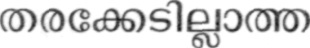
തരക്കേടില്ലാത്ത
